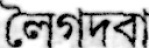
লৈগদবা
